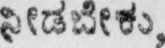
ನೀಡಬೇಕು,
